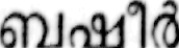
ബഷീര്‍
